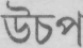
উচপ
